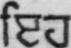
ਇਹ
